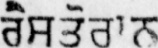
ਰੈਸਤੋਰਾਨ
